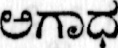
ಅಗಾಧ
